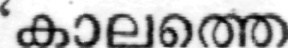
‘കാലത്തെ
